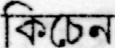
কিচেন
